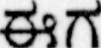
ಈಗ
